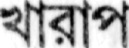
খারাপ
